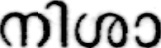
നിശാ
